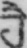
ਹੈ
